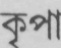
কৃপা
